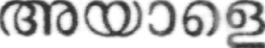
അയാളെ
